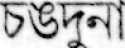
চঙদুনা
